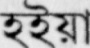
হইয়া
